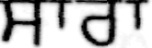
ਸਾਰਾ
